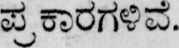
ಪ್ರಕಾರಗಳಿವೆ.
